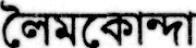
লৈমকোন্দা
